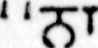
''ਨਾ
